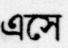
এসে
